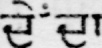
ਦੇਂਦਾ
